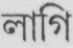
লাগি
